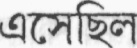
এসেছিল
